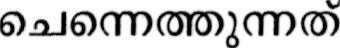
ചെന്നെത്തുന്നത്
